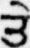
ਤੇ
